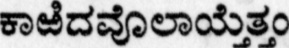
ಕಾಱದವೊಲಾಯ್ತೆತ್ತಂ
